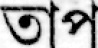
তাপ
